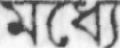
মধ্যে
